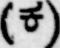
(ಕ)
